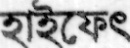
হাইফেৎ
